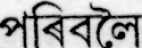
পৰিবলৈ
